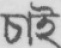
চাই
